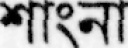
শাংনা
